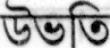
উভতি
